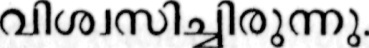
വിശ്വസിച്ചിരുന്നു.
